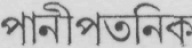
পানীপতনিক
